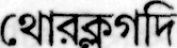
থোরক্লগদি
